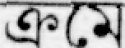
ক্রমে
